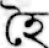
হৈ
